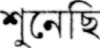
শুনেছি
